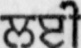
ਲਈ
